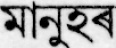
মানুহৰ
